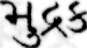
મુદ્રક
